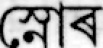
স্নোৰ
